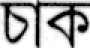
চাক
